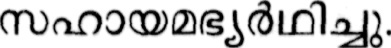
സഹായമഭ്യര്‍ഥിച്ചു.
